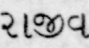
રાજીવ
